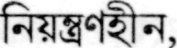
নিয়ন্ত্রণহীন,
